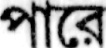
পারে
